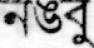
নঙবু
